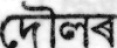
দৌলৰ
